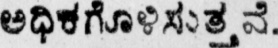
ಅಧಿಕಗೊಳಿಸುತ್ತವೆ.
